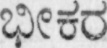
ಭೀಕರ
